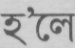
হ'লে
